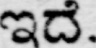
ಇದೆ.
